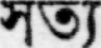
সত্য
